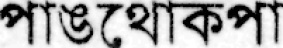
পাঙথোকপা
